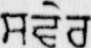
ਸਵੇਰ
